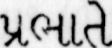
પ્રભાતે
